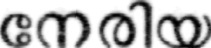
നേരിയ
